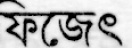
ফিজেৎ
